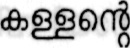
കള്ളന്റെ
